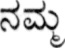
ನಮ್ಮ
